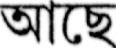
আছে
